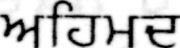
ਅਹਿਮਦ
